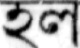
হল
